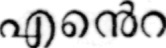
എന്റെ
